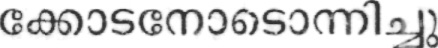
ക്കോടനോടൊന്നിച്ചു
